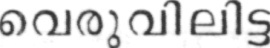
വെരുവിലിട്ട
